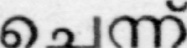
ചെന്ന്
